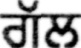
ਗੱਲ
